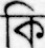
কি
